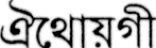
ঐথোয়গী
